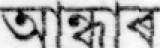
আন্ধাৰ
